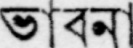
ভাবনা
